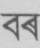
বৰ
